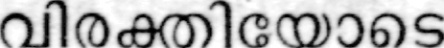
വിരക്തിയോടെ
